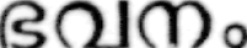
ഭവനം
